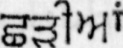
ਛੜੀਆਂ
